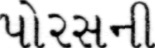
પોરસની
